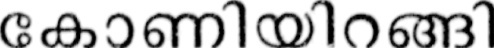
കോണിയിറങ്ങി
